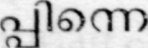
പ്പിന്നെ
